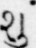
શું
